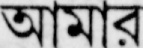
আমার
